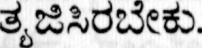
ತ್ಯಜಿಸಿರಬೇಕು.
